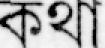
কথা
